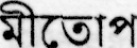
মীতোপ
